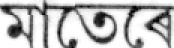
মাতেৰে
